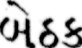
બેઠક
